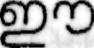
ഈ
